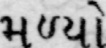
મળ્યો
